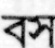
বস
